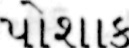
પોશાક
